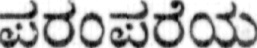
ಪರಂಪರೆಯ
